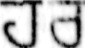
ਹਰ
